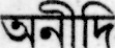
অনীদি
